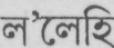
ল'লেহি
